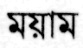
ময়াম
